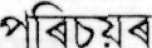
পৰিচয়ৰ
